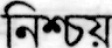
নিশ্চয়
